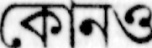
কোনও
